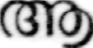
ആ
